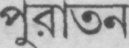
পুরাতন
